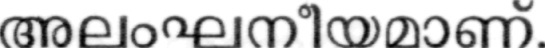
അലംഘനീയമാണ്.
